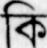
কি
